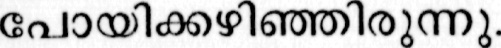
പോയിക്കഴിഞ്ഞിരുന്നു.
